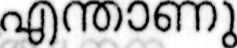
എന്താണു
